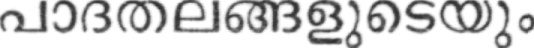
പാദതലങ്ങളുടെയും
